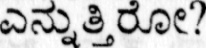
ಎನ್ನುತ್ತೀರೋ?
